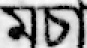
মচা
